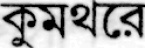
কুমথরে
